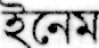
ইনেম
